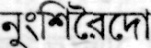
নুংশিরৈদো
